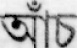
আঁচ
